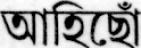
আহিছোঁ
